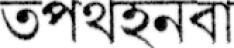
তপথহনবা
